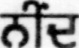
ਨੀਂਦ
